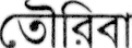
তৌরিবা
